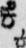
ಕ್ಕೆ
